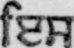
ਇਸ
